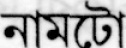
নামটো
